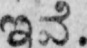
ಇವೆ.
